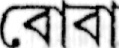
বোবা
